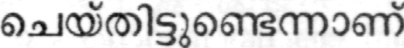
ചെയ്തിട്ടുണ്ടെന്നാണ്
